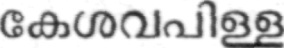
കേശവപിള്ള
